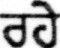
ਰਹੇ
